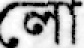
লো
